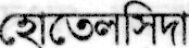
হোতেলসিদা
